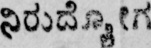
ನಿರುದ್ಯೋಗ
